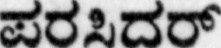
ಪರಸಿದರ್
